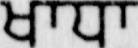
ਖਾਧਾ
